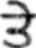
ਤੇ
